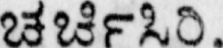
ಚರ್ಚಿಸಿರಿ.
